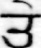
ਤੇ
